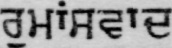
ਰੁਮਾਂਸਵਾਦ
